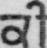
ਕੀ
